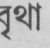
বৃথা
